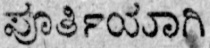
ಪೂರ್ತಿಯಾಗಿ
